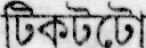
টিকটটো
